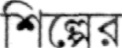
শিল্পের
